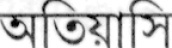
অতিয়াসি
